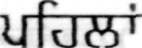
ਪਹਿਲਾਂ
